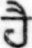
ਹੈ
